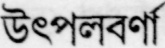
উত্পলবর্ণা
